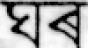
ঘৰ
